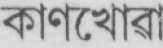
কাণখোৱা
